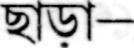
ছাড়া-
